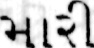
મારી
